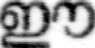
ഈ
